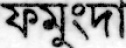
ফমুংদা
